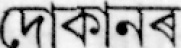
দোকানৰ
